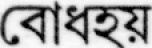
বোধহয়
